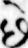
છે
